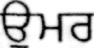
ਉਮਰ
